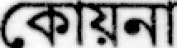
কোয়না
